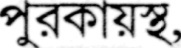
পুরকায়স্থ,
